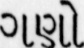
ગણો
